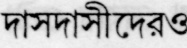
দাসদাসীদেরও
